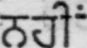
ਨਹੀਂ
